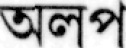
অলপ
